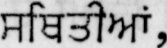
ਸਥਿਤੀਆਂ,
